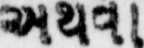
અથવા
